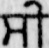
ਸੀ
